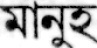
মানুহ
